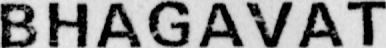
BHAGAVAT
